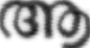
ആ
